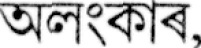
অলংকাৰ,
